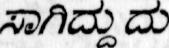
ಸಾಗಿದ್ದುದು
